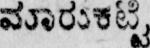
ಮಾರುಕಟ್ಟೆ
